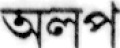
অলপ
